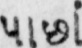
પાછાં
